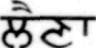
ਲੈਣਾ
